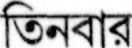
তিনবার
